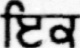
ਇਕ
